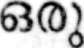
ഒരു
